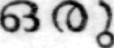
ഒരു
